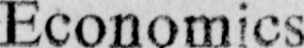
Economics
